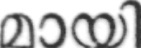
മായി
